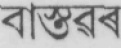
বাস্তৱৰ
